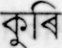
কুৰি
